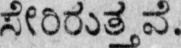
ಸೇರಿರುತ್ತವೆ.
